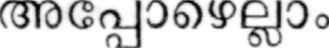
അപ്പോഴെല്ലാം
